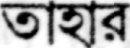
তাহার
